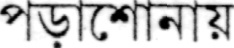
পড়াশোনায়
